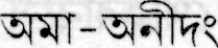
অমা-অনীদং
